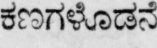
ಕಣಗಳೊಡನೆ
